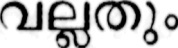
വല്ലതും
